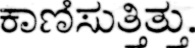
ಕಾಣಿಸುತ್ತಿತ್ತು.
